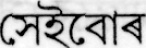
সেইবোৰ
